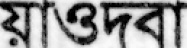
য়াওদবা
